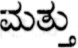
ಮತ್ತು
